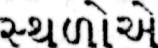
સ્થળોએ
